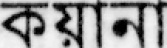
কয়ানা
